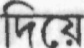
দিয়ে
